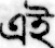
এই
